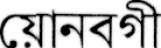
য়োনবগী
